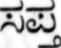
ಸಪ್ತ
